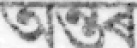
অন্তৰ
